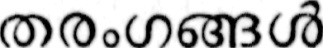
തരംഗങ്ങള്‍
